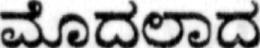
ಮೊದಲಾದ
